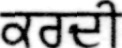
ਕਰਦੀ
